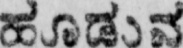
ಹೂಡುವ
